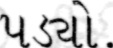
પડ્યો.
